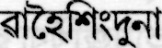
ৱাহৈশিংদুনা
